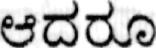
ಆದರೂ
